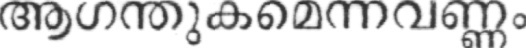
ആഗന്തുകമെന്നവണ്ണം
